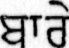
ਬਾਰੇ
